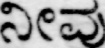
ನೀವು
